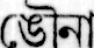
ঙৌনা
